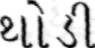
થોડી
